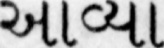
આવ્યા
